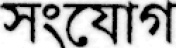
সংযোগ
